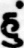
હું
